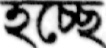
হচ্ছে
